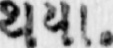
થયા.
